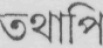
তথাপি
